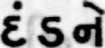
દંડને
